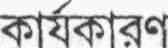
কার্যকারণ
